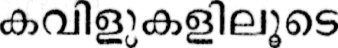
കവിളുകളിലൂടെ
